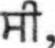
ਸੀ,
